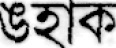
ঙহাক
